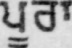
ਪੂਰਾ
